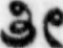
ತೀ
